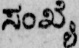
ಸಂಖ್ಯೆ
